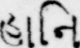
હાનિ
